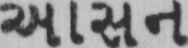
આસન
